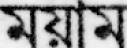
ময়াম
